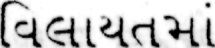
વિલાયતમાં
